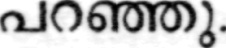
പറഞ്ഞു.
